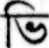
ভি
